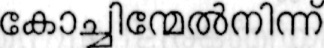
കോച്ചിന്മേല്‍നിന്ന്
